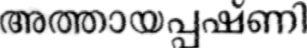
അത്തായപ്പഷ്ണി
